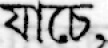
যাচে,
